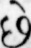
છે
